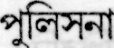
পুলিসনা
